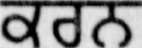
ਕਰਨ
